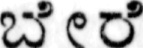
ಬೇರೆ
